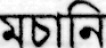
মচানি
